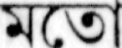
মতো
